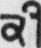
ਕੀ
